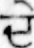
ਦੇ
